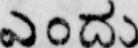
ಎಂದು
